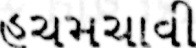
હચમચાવી
